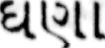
ઘણા
